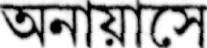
অনায়াসে
